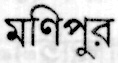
মণিপুর
